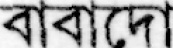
বাবাদো
